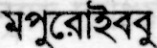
মপুরোইববু
